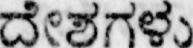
ದೇಶಗಳು
